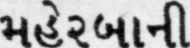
મહેરબાની
